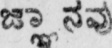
ಜ್ಞಾನವು
